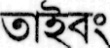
তাইবং
